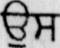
ਉਸ
